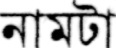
নামটা
